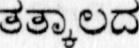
ತತ್ಕಾಲದ
